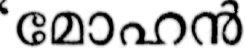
'മോഹന്‍
